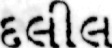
દલીલ
